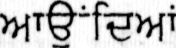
ਆਉਂਦਿਆਂ
